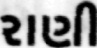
રાણી
